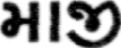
માજી
